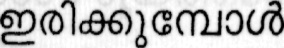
ഇരിക്കുമ്പോള്‍
